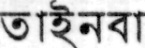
তাইনবা
